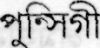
পুন্সিগী
